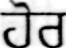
ਹੋਰ
